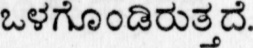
ಒಳಗೊಂಡಿರುತ್ತದೆ.
